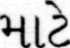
માટે
